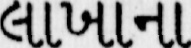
લાખાના
